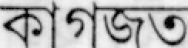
কাগজত
